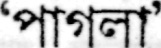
‘পাগলা’
